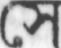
সে
